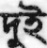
দুই
